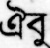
ঐবু
